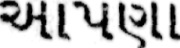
આપણા
